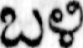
ಬಳಿ
